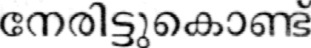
നേരിട്ടുകൊണ്ട്
